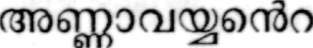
അണ്ണാവയ്യന്റെ
